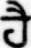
ਹੈ
